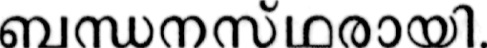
ബന്ധനസ്ഥരായി.
